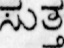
ಸುತ್ತ
